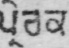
ਪ੍ਰੇਰਕ
